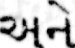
અને
